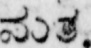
ಮತ.
